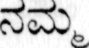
ನಮ್ಮ
